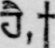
ਹੈ,†
